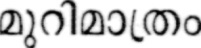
മുറിമാത്രം
